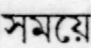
সময়ে
